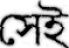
সেই
